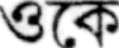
ওকে
